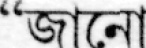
"জানো
